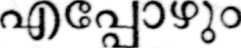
എപ്പോഴും
